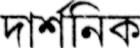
দার্শনিক
